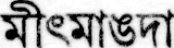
মীৎমাঙদা
